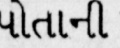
પોતાની
